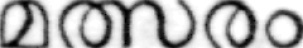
മത്സരം
